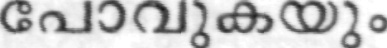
പോവുകയും
